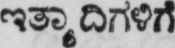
ಇತ್ಯಾದಿಗಳಿಗೆ
